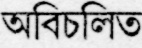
অবিচলিত
